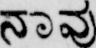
ನಾವು
